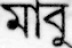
মাবু
